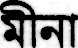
মীনা
